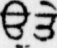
ਉਤੇ
